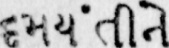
દમયંતીને
